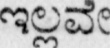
ಇಲ್ಲವೇ
